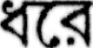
ধরে
